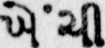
ખેંચી
